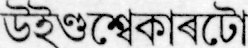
উইণ্ডশ্বেকাৰটো
